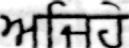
ਅਜਿਹੇ
